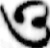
ও
